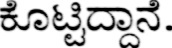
ಕೊಟ್ಟಿದ್ದಾನೆ.
